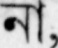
না,
